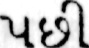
પછી
